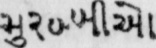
મુરબ્બીઓ
